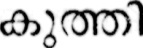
കുത്തി
